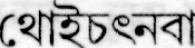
থোইচৎনবা
